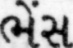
ભેંસ
